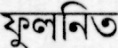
ফুলনিত
